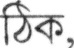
ঠিক,
